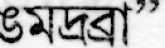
ঙমদ্রব্রা”
